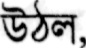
উঠল,
